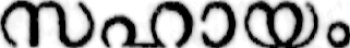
സഹായം
